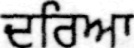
ਦਰਿਆ
